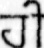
ਹੀ
